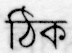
ঠিক
